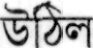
উঠিল
